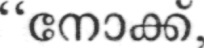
"നോക്ക്,
